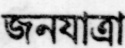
জনযাত্রা
